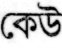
কেউ
